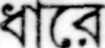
ধারে
